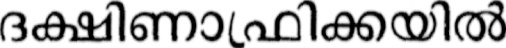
ദക്ഷിണാഫ്രിക്കയില്‍
